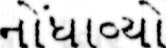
નોંધાવ્યો
